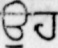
ਉਹ
